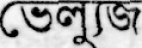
ভেল্যুজ
